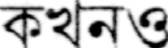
কখনও
